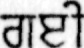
ਗਈ
